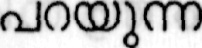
പറയുന്ന
